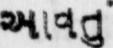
આવતું
